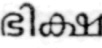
ഭിക്ഷ
